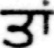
ਤਾਂ
